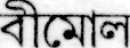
বীমোল
